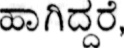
ಹಾಗಿದ್ದರೆ,
